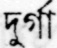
দুর্গা
